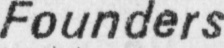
Founders
